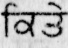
ਕਿਤੇ
